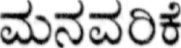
ಮನವರಿಕೆ
